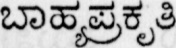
ಬಾಹ್ಯಪ್ರಕೃತಿ
